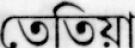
তেতিয়া
